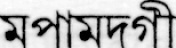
মপামদগী
